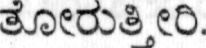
ತೋರುತ್ತೀರಿ.
